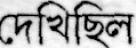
দেখিছিল
